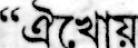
“ঐখোয়
